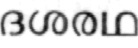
ദശരഥ
